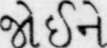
જોઈને
